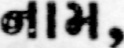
નામ,
